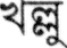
খল্লু
